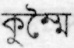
কুম্মৈ
